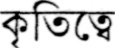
কৃতিত্বে
